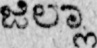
ಜಿಲ್ಲಾ
